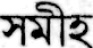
সমীহ
